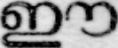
ഈ
